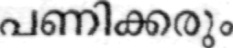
പണിക്കരും
